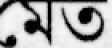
মেত
